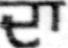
ਦਾ
